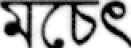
মচেৎ
